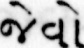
જેવો
